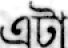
এটা
